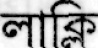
লাক্লি
